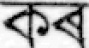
কৰ
